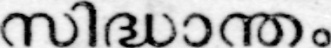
സിദ്ധാന്തം
